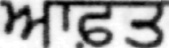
ਆਫ਼ਤ
